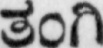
ತಂಗಿ
